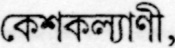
কেশকল্যাণী,
